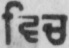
ਵਿਚ
